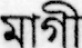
মাগী
